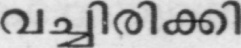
വച്ചിരിക്കി
